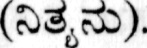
(ನಿತ್ಯನು).
